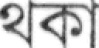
থকা
